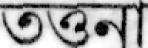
তত্তনা
